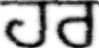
ਹਰ
